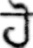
ਹੋ
